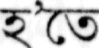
হ'তে
